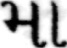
મા
